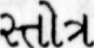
સ્તોત્ર
